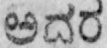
ಅದರ
